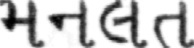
મનલત
